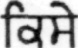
ਕਿਸੇ
